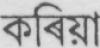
কৰিয়া
